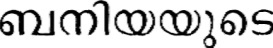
ബനിയയുടെ
